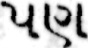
પણ
